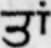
ਤਾਂ
